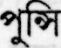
পুন্সি
